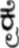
ಕೈ
